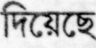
দিয়েছে
